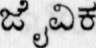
ಜೈವಿಕ
